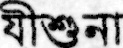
যীশুনা
